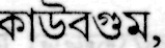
কাউবগুম,
